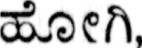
ಹೋಗಿ,
